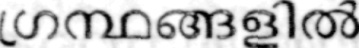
ഗ്രന്ഥങ്ങളില്‍
